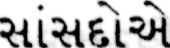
સાંસદોએ
